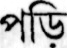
পড়ি
